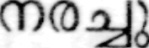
നരച്ചു
